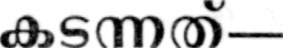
കടന്നത്-
